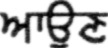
ਆਉਣ
